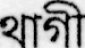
থাগী
